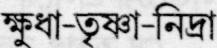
ক্ষুধা-তৃষ্ণা-নিদ্রা
